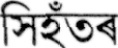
সিহঁতৰ
